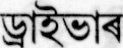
ড্ৰাইভাৰ
